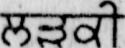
ਲੜਕੀ
